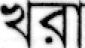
খরা
